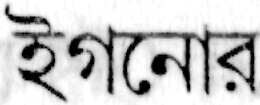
ইগনোর
